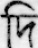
দি
